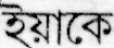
ইয়াকে
